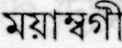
ময়াম্বগী
